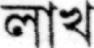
লাখ
